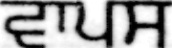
ਵਾਪਸ
